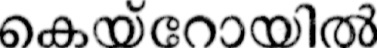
കെയ്റോയില്‍
